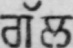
ਗੱਲ
